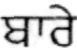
ਬਾਰੇ
